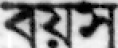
বয়স
